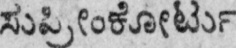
ಸುಪ್ರೀಂಕೋರ್ಟು
